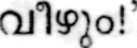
വീഴും!’
